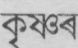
কৃষ্ণৰ
